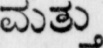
ಮತ್ತು
